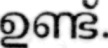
ഉണ്ട്.
